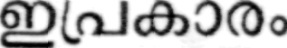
ഇപ്രകാരം
